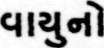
વાયુનો
